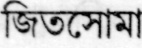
জিতসোমা
